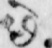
છે.
